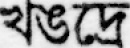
খঙদ্রে
